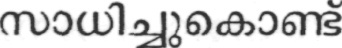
സാധിച്ചുകൊണ്ട്
